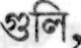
গুলি,
